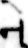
ને
